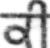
ਕੀ
